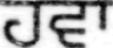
ਹਵਾ
